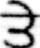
ਤੇ
